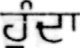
ਹੁੰਦਾ
